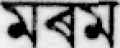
মৰম
